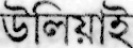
উলিয়াই
